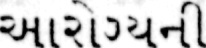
આરોગ્યની
